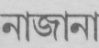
নাজানা
